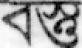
বস্তু
